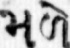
મળે
